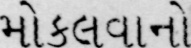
મોકલવાનો
